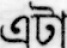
এটা
